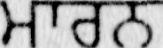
ਮਾਰਨ
